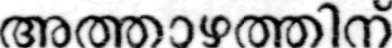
അത്താഴത്തിന്
